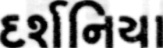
દર્શનિયા
